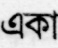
একা
